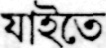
যাইতে
